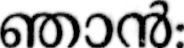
ഞാന്‍:
